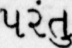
પરંતુ
